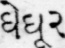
ઘેઘુર
